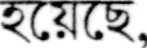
হয়েছে,
